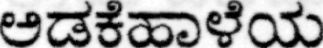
ಅಡಕೆಹಾಳೆಯ
